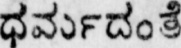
ಧರ್ಮದಂತೆ
